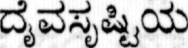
ದೈವಸೃಷ್ಟಿಯ
